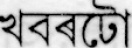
খবৰটো
